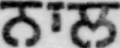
ਨਾਲ
